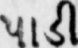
પાડી
